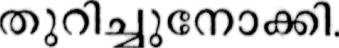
തുറിച്ചുനോക്കി.
